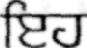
ਇਹ
